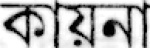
কায়না
